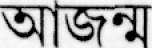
আজন্ম
